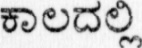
ಕಾಲದಲ್ಲಿ
